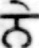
ਨੇ
